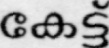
കേട്ട്
